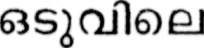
ഒടുവിലെ
